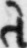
તે
